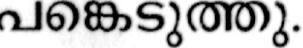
പങ്കെടുത്തു.
